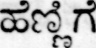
ಹೆಣ್ಣಿಗೆ
